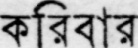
করিবার
